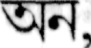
অন,
